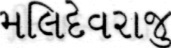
મલિદેવરાજુ
